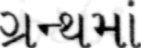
ગ્રન્થમાં
